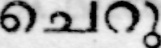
ചെറു
